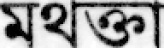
মথক্তা
